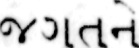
જગતને
